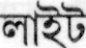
লাইট
